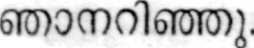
ഞാനറിഞ്ഞു.
